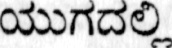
ಯುಗದಲ್ಲಿ
